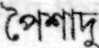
পৈশাদু
